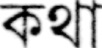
কথা
